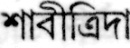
শাবীত্রিদা
